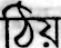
ঠিয়
